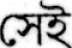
সেই
